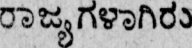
ರಾಜ್ಯಗಳಾಗಿರು
